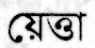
য়েত্তা
